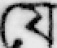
যে
